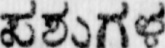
ಪಶುಗಳ
